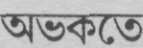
অভকতে
